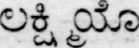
ಲಕ್ಷ್ಮಿಯೊ
